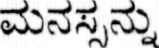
ಮನಸ್ಸನ್ನು
